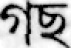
গছ
